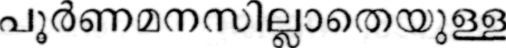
പൂര്‍ണമനസില്ലാതെയുള്ള
